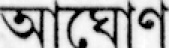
আঘোণ
